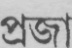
প্ৰজা
